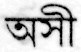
অসী
